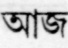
আজ
